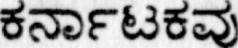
ಕರ್ನಾಟಕವು
